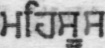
ਮਹਿਸੂਸ
